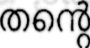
തന്റെ
